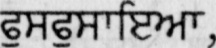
ਫੁਸਫੁਸਾਇਆ,
